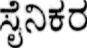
ಸೈನಿಕರ
